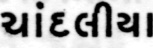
ચાંદલીયા
